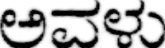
ಅವಳು
